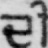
ਦੀ
